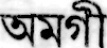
অমগী
